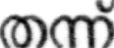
തന്ന്
